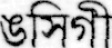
ঙসিগী
